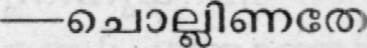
-ചൊല്ലിണതേ
